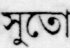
সুতো
